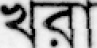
খরা
